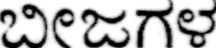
ಬೀಜಗಳ
